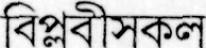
বিপ্লবীসকল
